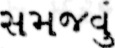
સમજવું
